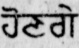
ਹੋਣਗੇ
